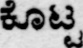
ಕೊಟ್ಟ
